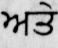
ਅਤੇ
